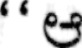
"ಆ
